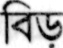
বিড়
